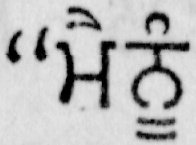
''ਮੈਨੂੰ
